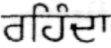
ਰਹਿੰਦਾ
